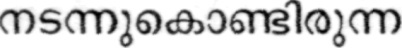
നടന്നുകൊണ്ടിരുന്ന
